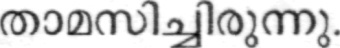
താമസിച്ചിരുന്നു.
